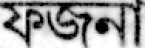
ফজনা
